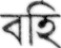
বহি
